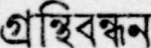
গ্রন্থিবন্ধন
